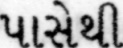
પાસેથી
